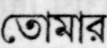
তোমার
